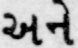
અને
